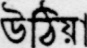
উঠিয়া
